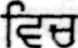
ਵਿਚ
